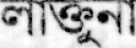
লাক্তুনা
